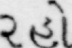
રહો
